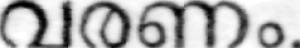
വരണം.
